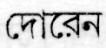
দোরেন
